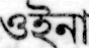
ওইনা
